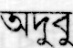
অদুবু
